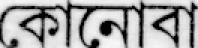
কোনোবা
